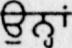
ਉਨ੍ਹਾਂ
